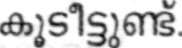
കൂടീട്ടുണ്ട്.
